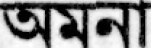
অমনা
